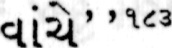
વાંચે"૧૮૩
